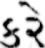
કરે
